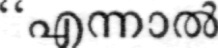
“എന്നാല്‍
